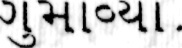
ગુમાવ્યા.
